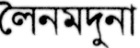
লৈনমদুনা
